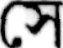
সে
